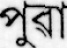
পুৱা
